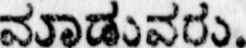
ಮಾಡುವರು.
